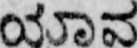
ಯಾವ
